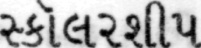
સ્કોલરશીપ
